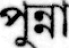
পুন্না
